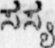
ಸಸ್ಯ
